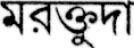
মরক্তুদা
